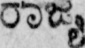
ರಾಜ್ಯ
